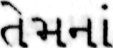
તેમનાં
